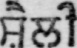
ਸ਼ੈਲੀ
